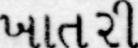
ખાતરી
